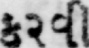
કરવી
